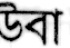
উবা
